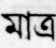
মাত্র
